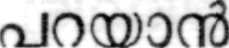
പറയാന്‍
